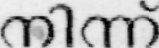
നിന്ന്
